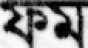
ফম
